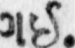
ગઈ.
